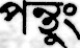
পন্থুং
